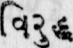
વિરુદ્ધ
